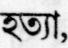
হত্যা,
